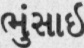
ભુંસાઈ
